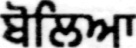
ਬੋਲਿਆ
